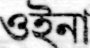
ওইনা
